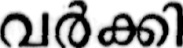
വര്‍ക്കി
